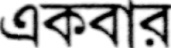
একবার
